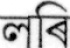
লৰি
